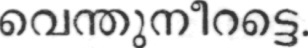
വെന്തുനീറട്ടെ.
